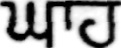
ਘਾਹ
